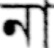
না
